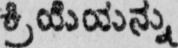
ಕ್ರಿಯಯನ್ನು
